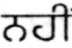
ਨਹੀਂ
